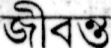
জীবন্ত
